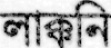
লাক্কনি
